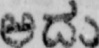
ಅದು
